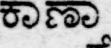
ಕಾಣ್ತಾ
